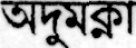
অদুমক্না
